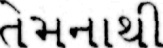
તેમનાથી
